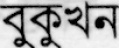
বুকুখন
